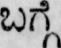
ಬಗ್ಗೆ
